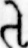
તે
